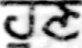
ਹੁਣ
